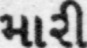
મારી
